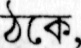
ঠকে,
